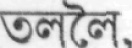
তললৈ,
